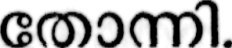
തോന്നി.
